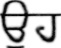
ਉਹ
